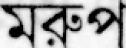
মরুপ
